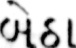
બેઠા
